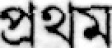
প্রথম
